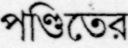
পণ্ডিতের
